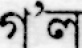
গ'ল
